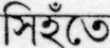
সিহঁতে
